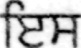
ਇਸ
